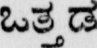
ಒತ್ತಡ
